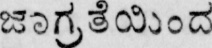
ಜಾಗ್ರತೆಯಿಂದ
